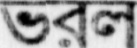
ভরল
